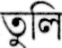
তুলি
